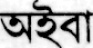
অইবা
